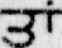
ਤਾਂ
